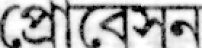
প্রোবেসন
